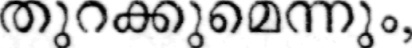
തുറക്കുമെന്നും,
